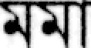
মমা
